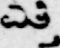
ಎತ್ತಿ
